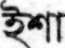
ইশা
